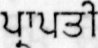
ਪ੍ਰਾਪਤੀ
